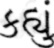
કહ્યું
